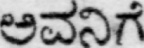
ಅವನಿಗೆ
